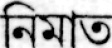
নিমাত
